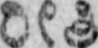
ರೀತಿ
